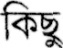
কিছু
